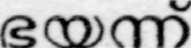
ഭയന്ന്
